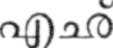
എഛ്
